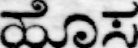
ಹೊಸ
